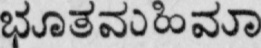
ಭೂತಮಹಿಮಾ
